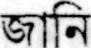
জানি
